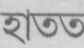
হাতত
